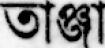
তাঞ্জা
